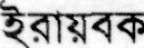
ইরায়বক
